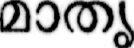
മാതൃ
